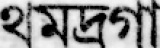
থমদ্রগা
